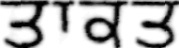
ਤਾਕਤ
